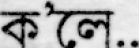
ক'লে..
